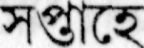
সপ্তাহে
